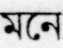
মনে
